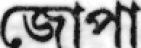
জোপা
